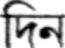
দিন
